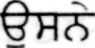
ਉਸਨੇ
